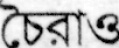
চৈরাও
